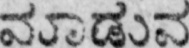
ಮಾಡುವ
